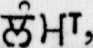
ਲੰਮਾ,
